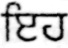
ਇਹ
